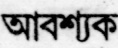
আবশ্যক
